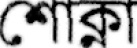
শোক্না
